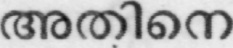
അതിനെ
